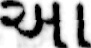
આ
